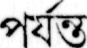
পর্যন্ত
